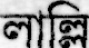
লাল্লি
